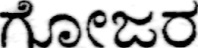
ಗೋಜರ
